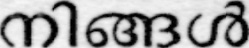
നിങ്ങള്‍
